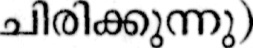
ചിരിക്കുന്നു)
